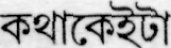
কথাকেইটা
